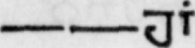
-----ਹਾਂ
